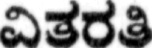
ವಿತರತಿ
